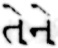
તેને
